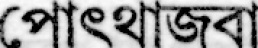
পোৎথাজবা
